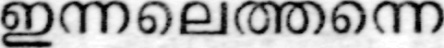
ഇന്നലെത്തന്നെ
